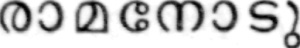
രാമനോടു
